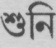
শুনি
